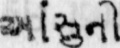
આંસુની
